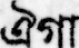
ঐগা
